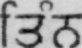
ਤਿੰਨ
